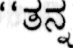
"ತನ್ನ
